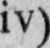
iv)
